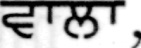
ਵਾਲਾ,
